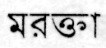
মরক্তা
